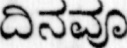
ದಿನವೂ
